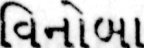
વિનોબા
